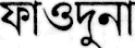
ফাওদুনা
